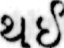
થઈ
